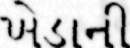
ખેડાની
